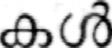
കള്‍
